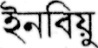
ইনবিয়ু
